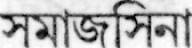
সমাজসিনা
